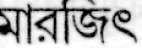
মারজিৎ
